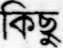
কিছু
